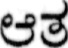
ಆತ
